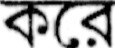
করে
